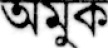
অমুক
